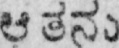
ಆತನು
